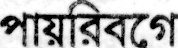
পায়রিবগে
